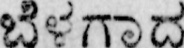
ಬೆಳಗಾದ
